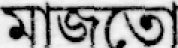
মাজতো
